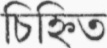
চিহ্নিত
